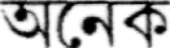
অনেক
